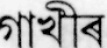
গাখীৰ
